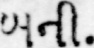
બની.
